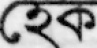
হেক
